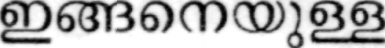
ഇങ്ങനെയുള്ള
